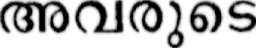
അവരുടെ
